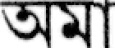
অমা
